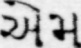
એમ
